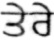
ਤੇਰੇ
